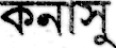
কনাসু
